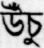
উঁচু
